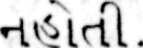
નહોતી.
